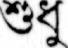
শুধু
